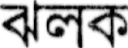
ঝলক
